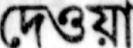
দেওয়া
